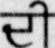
ਦੀ
